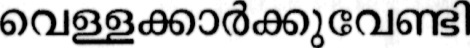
വെള്ളക്കാര്‍ക്കുവേണ്ടി
